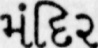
મંદિર
